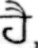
ਹੈ,
